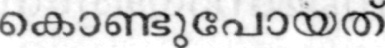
കൊണ്ടുപോയത്
